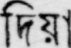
দিয়া
